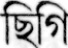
ছিগি
